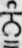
ਨੂੰ
